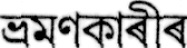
ভ্রমণকাৰীৰ
